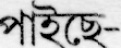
পাইছে-
